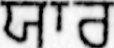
ਯਾਰ
